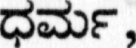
ಧರ್ಮ,
